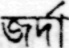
জর্দা
